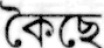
কৈছে
